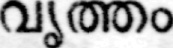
വൃത്തം
